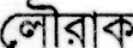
লৌরাক
